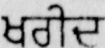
ਖਰੀਦ
